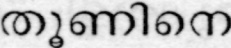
തൂണിനെ
